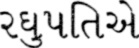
રઘુપતિએ
